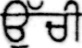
ਉੱਚੀ
